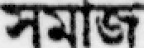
সমাজ
